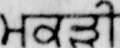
ਮਕੜੀ
